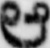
ಆ
